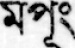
মপূং
